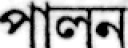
পালন
